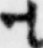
ન
